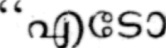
"എടോ
